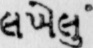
લખેલું
